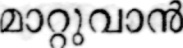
മാറ്റുവാന്‍
